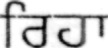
ਰਿਹਾ
